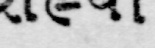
શલ્યા
